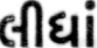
લીધાં
